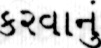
કરવાનું
